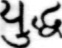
યુદ્ધ
